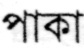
পাকা
